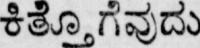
ಕಿತ್ತೊಗೆವುದು
